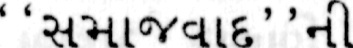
"સમાજવાદ"ની
